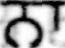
ਨਾ
